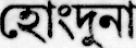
হোংদুনা
